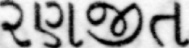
રણજીત
